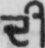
ਦੀ
